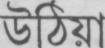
উঠিয়া
